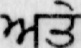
ਅਤੇ
